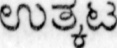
ಉತ್ಕಟ
